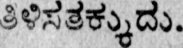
ತಿಳಿಸತಕ್ಕುದು.
